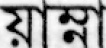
য়াম্না
